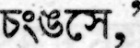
চংঙসে,’
